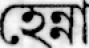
হেন্না
